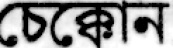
চেক্কোন
